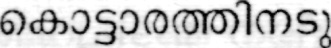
കൊട്ടാരത്തിനടു
